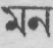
মন
